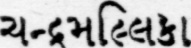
ચન્દ્રમલ્લિકા
